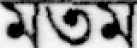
মতম
